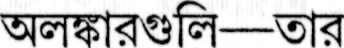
অলঙ্কারগুলি-তার
